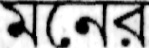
মনের
